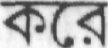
করে
